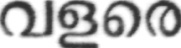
വളരെ
